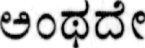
ಅಂಥದೇ
